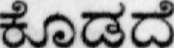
ಕೊಡದೆ
